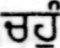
ਚਹੁੰ
